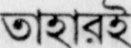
তাহারই
